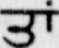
ਤਾਂ
